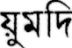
য়ুমদি
